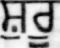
ਸ਼ੁਰੂ
